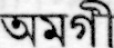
অমগী
